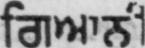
ਗਿਆਨੀ
